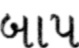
બાપ
